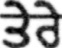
ਤੇਰੇ
